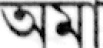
অমা
